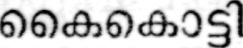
കൈകൊട്ടി
